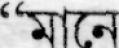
"মানে
